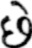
છે
